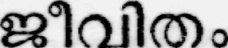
ജീവിതം
